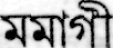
মমাগী
